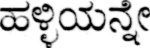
ಹಳ್ಳಿಯನ್ನೇ
